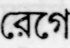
রেগে
